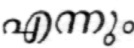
എന്നും
